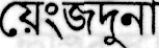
য়েংজদুনা
